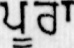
ਪੂਰਾ
